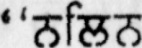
''ਨਲਿਨ
